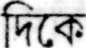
দিকে
